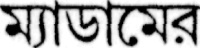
ম্যাডামের
